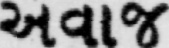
અવાજ
